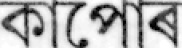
কাপোৰ
